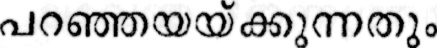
പറഞ്ഞയയ്ക്കുന്നതും
